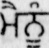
ਮੈਨੂੰ
